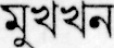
মুখখন
